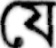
যে
